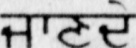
ਜਾਣਦੇ
